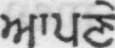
ਆਪਣੇ
